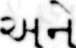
અને
